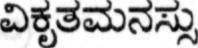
ವಿಕೃತಮನಸ್ಸು
